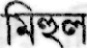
মিহুল
